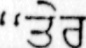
''ਤੇਰ
